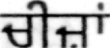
ਚੀਜ਼ਾਂ
